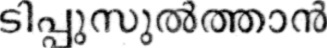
ടിപ്പുസുല്‍ത്താന്‍
